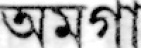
অমগা
